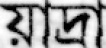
য়াদ্রা
